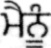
ਮੈਨੂੰ
